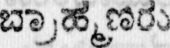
ಬ್ರಾಹ್ಮಣರು
